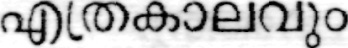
എത്രകാലവും
